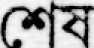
শেষ
